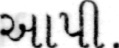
આપી.
